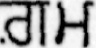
ਗ਼ਮ
